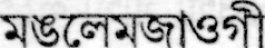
মঙলেমজাওগী
